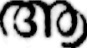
ആ
